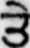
ਤੇ
